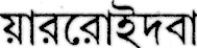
য়াররোইদবা
